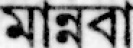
মান্নবা
